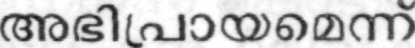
അഭിപ്രായമെന്ന്
